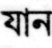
যান
